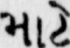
માટે
